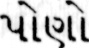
પોણો
